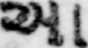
આ
